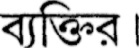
ব্যক্তির।
